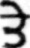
ਤੇ
